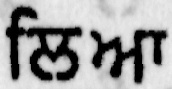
ਲਿਆ
